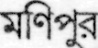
মণিপুর
